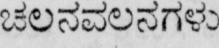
ಚಲನವಲನಗಳು
